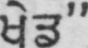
ਖੇਡ''
